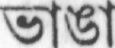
ভাঙা
